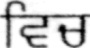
ਵਿਚ
